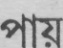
পায়
